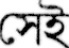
সেই
